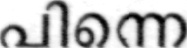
പിന്നെ
